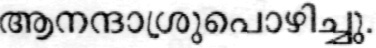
ആനന്ദാശ്രുപൊഴിച്ചു.
